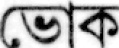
ভোক
